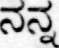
ನನ್ನ
